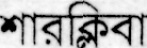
শারক্লিবা
